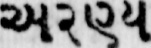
અરણ્ય
